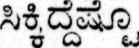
ಸಿಕ್ಕಿದ್ದೆಷ್ಟೊ
